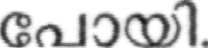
പോയി.
